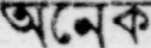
অনেক
